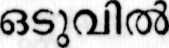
ഒടുവില്‍
